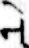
ને
